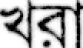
খরা
